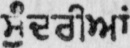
ਸੁੰਦਰੀਆਂ
